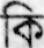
কি
